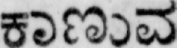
ಕಾಣುವ
